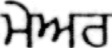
ਮੇਅਰ
